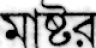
মাষ্টর
